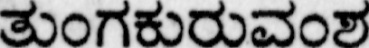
ತುಂಗಕುರುವಂಶ
